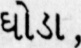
ઘોડા,
